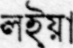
লইয়া
